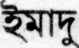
ইমাদু
